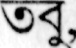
তবু,
